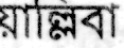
য়াল্লিবা
